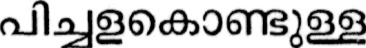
പിച്ചളകൊണ്ടുള്ള
